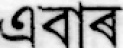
এবাৰ
